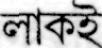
লাকই
